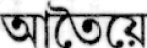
আতৈয়ে
